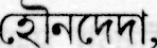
হৌনদেদা,
